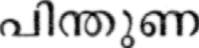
പിന്തുണ
